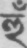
হুঁ
